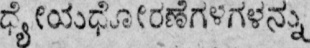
ಧ್ಯೇಯಧೋರಣೆಗಳಗಳನ್ನು
